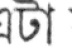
এটা
